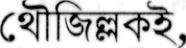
থৌজিল্লকই,
